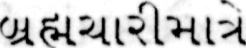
બ્રહ્મચારીમાત્રે
